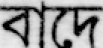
বাদে
